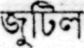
জুটিল
